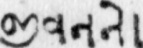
જીવનનો
